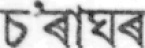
চ'ৰাঘৰ
